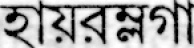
হায়রম্লগা
